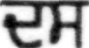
ਦਸ
